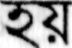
হয়
